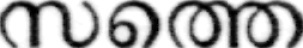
സത്തെ
